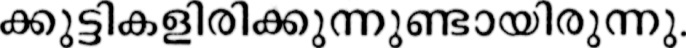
ക്കുട്ടികളിരിക്കുന്നുണ്ടായിരുന്നു.
